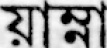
য়াম্না
